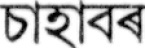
চাহাবৰ
